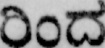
ರಿಂದ
